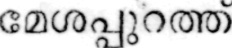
മേശപ്പുറത്ത്
